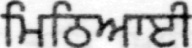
ਮਿਠਿਆਈ
